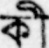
কী
